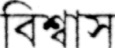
বিশ্বাস
